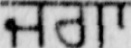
ਜਗਾ
